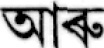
আৰু
